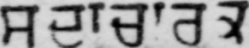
ਸਦਾਚਾਰਕ
